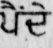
ਪੈਂਦੇ
